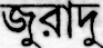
জুরাদু
